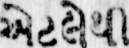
એટલેથી
